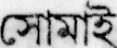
সোমাই
